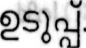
ഉടുപ്പ്.
